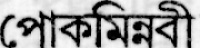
পোকমিন্নবী
